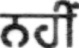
ਨਹੀਂ
